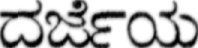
ದರ್ಜೆಯ
